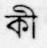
কী
